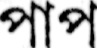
পাপ
